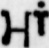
ਮਾਂ
